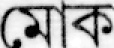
মোক
